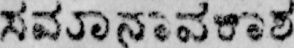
ಸಮಾನಾವಕಾಶ
